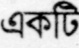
একটি
